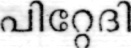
പിറ്റേദി
